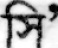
সি’
